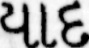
યાદ
